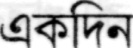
একদিন
